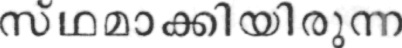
സ്ഥമാക്കിയിരുന്ന
